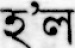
হ'ল
